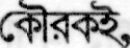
কৌরকই,
